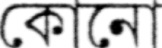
কোনো
